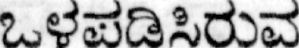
ಒಳಪಡಿಸಿರುವ
